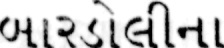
બારડોલીના
